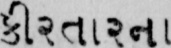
કીરતારના
